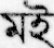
মই
